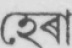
হেৰা
